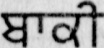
ਬਾਕੀ
